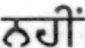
ਨਹੀਂ
